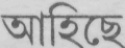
আহিছে
